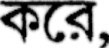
করে,
